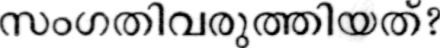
സംഗതിവരുത്തിയത്?
